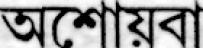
অশোয়বা
